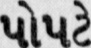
પોપટે
